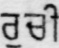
ਰੁਚੀ
